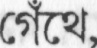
গেঁথে,
